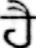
ਹੈ
